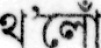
থ'লোঁ
